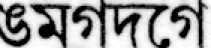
ঙমগদগে
